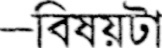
-বিষয়টা
